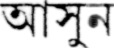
আসুন
